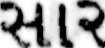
સાર
